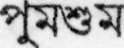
পুমশুম
